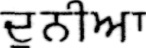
ਦੁਨੀਆ
